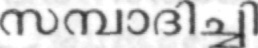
സമ്പാദിച്ചി
